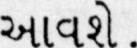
આવશે.
